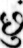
છું
